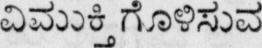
ವಿಮುಕ್ತಿಗೊಳಿಸುವ
